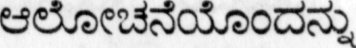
ಆಲೋಚನೆಯೊಂದನ್ನು
